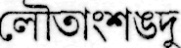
লৌতাংশঙদু
